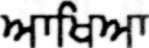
ਆਖਿਆ
